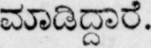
ಮಾಡಿದ್ದಾರೆ.
